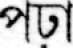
পঢ়া
